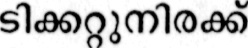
ടിക്കറ്റുനിരക്ക്
